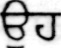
ਉਹ
